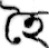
হৈ
